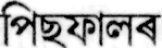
পিছফালৰ
